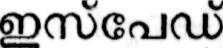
ഇസ്പേഡ്
